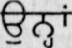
ਉਨ੍ਹਾਂ
